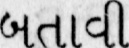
બતાવી
